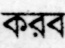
করব
